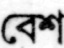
বেশ
